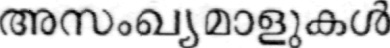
അസംഖ്യമാളുകള്‍
